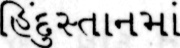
હિંદુસ્તાનમાં
